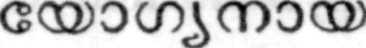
യോഗ്യനായ
